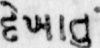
દેખાતું
